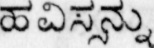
ಹವಿಸ್ಸನ್ನು
